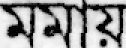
মমায়
